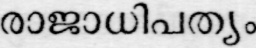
രാജാധിപത്യം
